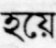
হয়ে
